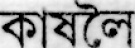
কাষলৈ
